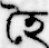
হৈ
